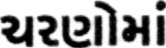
ચરણોમાં
